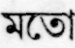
মতো
